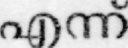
എന്ന്
